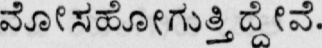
ಮೋಸಹೋಗುತ್ತಿದ್ದೇವೆ.
